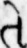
તે
